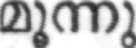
മൂന്നു
